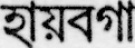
হায়বগা
